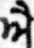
ਐ
